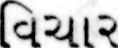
વિચાર
